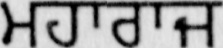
ਮਹਾਰਾਜ
